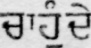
ਚਾਹੁੰਦੇ
